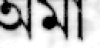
অমা
